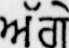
ਅੱਗੇ
